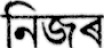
নিজৰ
